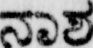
ನಾಶ
